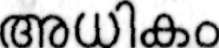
അധികം
